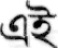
এই
